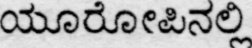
ಯೂರೋಪಿನಲ್ಲಿ
